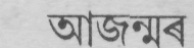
আজন্মৰ
